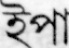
ইপা
